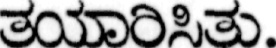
ತಯಾರಿಸಿತು.
